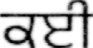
ਕਈ
